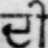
ਦੀ
